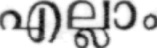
എല്ലാം
